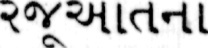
રજૂઆતના
